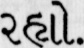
રહ્યો.
